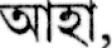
আহা,
